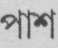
পাশ
